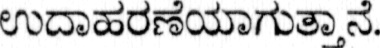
ಉದಾಹರಣೆಯಾಗುತ್ತಾನೆ.
